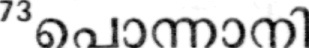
73പൊന്നാനി
